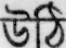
উঠি
